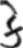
કે
